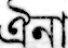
ঐনা
